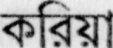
করিয়া
